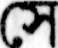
সে
